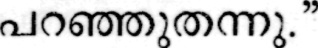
പറഞ്ഞുതന്നു."
